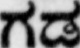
ಗಡ
